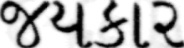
જયકાર
